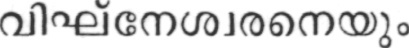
വിഘ്നേശ്വരനെയും
